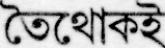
তৈথোকই
